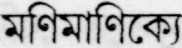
মণিমাণিক্যে
